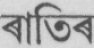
ৰাতিৰ
